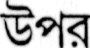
উপর
